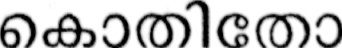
കൊതിതോ
